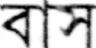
বাস
